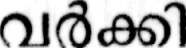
വര്‍ക്കി
